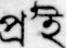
প্র'ই
